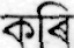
কৰি
